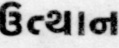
ઉત્થાન
